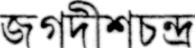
জগদীশচন্দ্র
